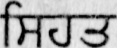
ਸਿਹਤ
